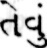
તેવું
